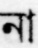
না
